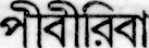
পীবীরিবা
